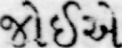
જોઈએ
